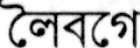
লৈবগে
